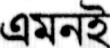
এমনই
